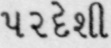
પરદેશી
